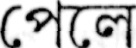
পেলে
